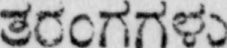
ತರಂಗಗಳು
